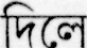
দিলে
